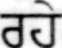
ਰਹੇ
